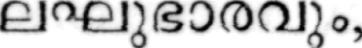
ലഘുഭാരവും,
